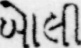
બોલી
